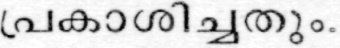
പ്രകാശിച്ചതും.
